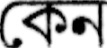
কেন
